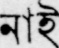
নাই
